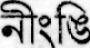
নীংঙি
